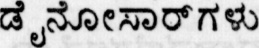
ಡೈನೋಸಾರ್ಗಳು
